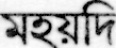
মহয়দি
